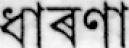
ধাৰণা
